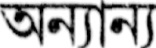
অন্যান্য
